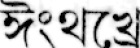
ঈংথখ্রে
